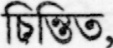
চিন্তিত,
